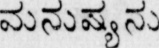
ಮನುಷ್ಯನು
